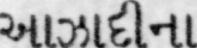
આઝાદીના
